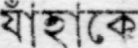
যাঁহাকে
